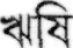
ঋষি
